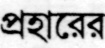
প্রহারের
